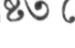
দৃষ্টিত
